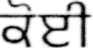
ਕੋਈ
